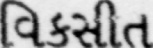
વિકસીત
